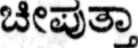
ಚೀಪುತ್ತಾ
